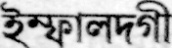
ইম্ফালদগী
